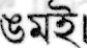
ঙমই।
